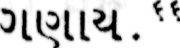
ગણાય.૬૬
